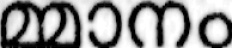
മ്മാനം
